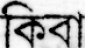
কিবা
